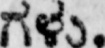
ಗಳು.
